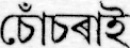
চোঁচৰাই
